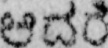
ಆದರೆ
